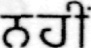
ਨਹੀਂ
